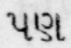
પણ
